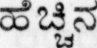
ಹೆಚ್ಚಿನ
